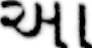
આ
